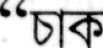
“চাক
